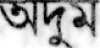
অদুম
